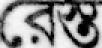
রেস্ত
